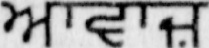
ਆਵਾਜ਼
